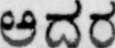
ಅದರ
